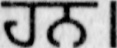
ਹਨ।
